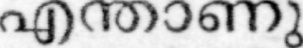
എന്താണു
